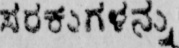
ಸರಕುಗಳನ್ನು
